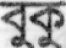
বুকু
